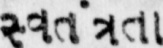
સ્વંત્રતા
